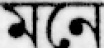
মনে
